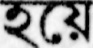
হয়ে
